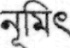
নূমিৎ
